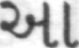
આ
